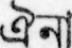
ঐনা
